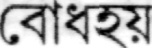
বোধহয়
